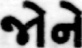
જોને
